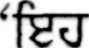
'ਇਹ
